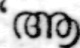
‘ആ
